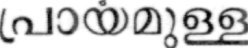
പ്രായമുള്ള
